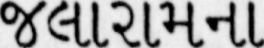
જલારામના
